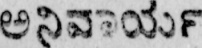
ಅನಿವಾರ್ಯ
